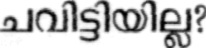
ചവിട്ടിയില്ല?
